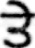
ਤੇ
